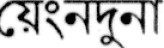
য়েংনদুনা
